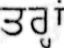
ਤਰ੍ਹਾਂ
